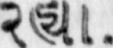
રહ્યા.
